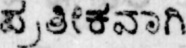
ಪ್ರತೀಕವಾಗಿ
